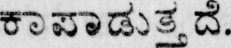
ಕಾಪಾಡುತ್ತದೆ.
